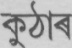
কুঠাৰ
